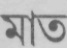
মাত
